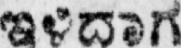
ಇಳಿದಾಗ
